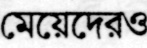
মেয়েদেরও
